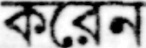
করেন
